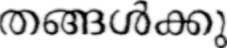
തങ്ങള്‍ക്കു
